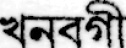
খনবগী
